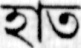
হাত
